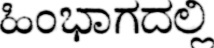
ಹಿಂಭಾಗದಲ್ಲಿ
